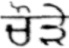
ਚੌੜੇ
